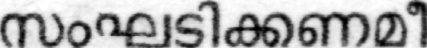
സംഘടിക്കണമീ
